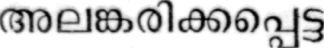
അലങ്കരിക്കപ്പെട്ട
